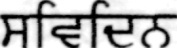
ਸਵਿਦਿਨ
